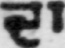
ਦਾ
